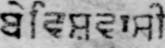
ਬੇਵਿਸ਼ਵਾਸੀ
